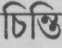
চিন্তি
